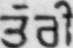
ਤੋਰੀ
